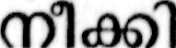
നീക്കി
